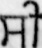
ਸੀ
